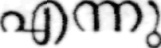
എന്നു
